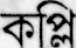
কপ্লি
